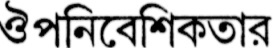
ঔপনিবেশিকতার
